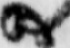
જ
